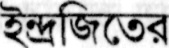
ইন্দ্রজিতের
